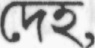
দেহ,
